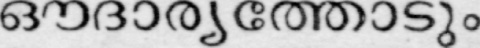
ഔദാര്യത്തോടും
